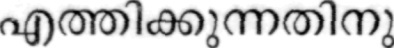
എത്തിക്കുന്നതിനു
